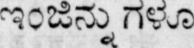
ಇಂಜಿನ್ನುಗಳೂ
